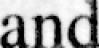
and
